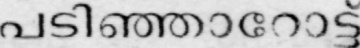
പടിഞ്ഞാറോട്ട്
